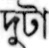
দুটা
